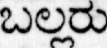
ಬಲ್ಲರು
